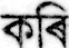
কৰি
